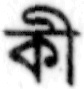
কী
